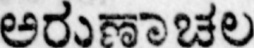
ಅರುಣಾಚಲ
